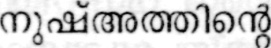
നുഷ്അത്തിന്റെ
